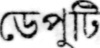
ডেপুটি
